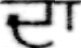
ਦਾ
